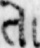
તો
